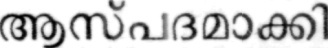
ആസ്പദമാക്കി
